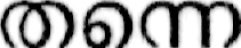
തന്നെ
